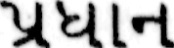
પ્રધાન
